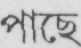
পাছে
